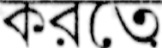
করতে
